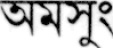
অমসুং
